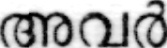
അവര്‍
